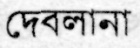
দেবলানা
